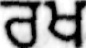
ਰਖ
